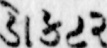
ડોક્ટર
